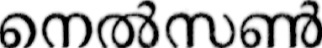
നെല്‍സണ്‍
